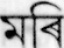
মৰি
